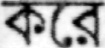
করে
